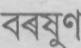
বৰষুণ
